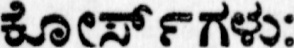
ಕೋರ್ಸ್‌ಗಳು:
